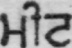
ਮੀਟ
